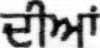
ਦੀਆਂ
